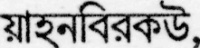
য়াহনবিরকউ,
